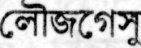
লৌজগেসু
